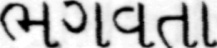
ભગવતા
